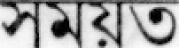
সময়ত
